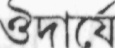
ঔদার্যে
